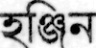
হঞ্জিন
